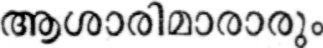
ആശാരിമാരാരും
